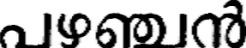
പഴഞ്ചന്‍
